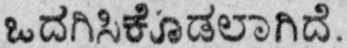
ಒದಗಿಸಿಕೊಡಲಾಗಿದೆ.
